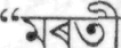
"মৰতী
